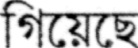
গিয়েছে
